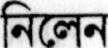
নিলেন
